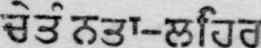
ਚੇਤੰਨਤਾ-ਲਹਿਰ
